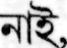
নাই,
